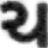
ચ
